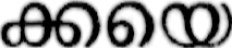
ക്കയെ
